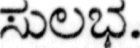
ಸುಲಭ.
